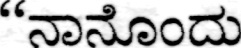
"ನಾನೊಂದು
